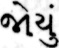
જોયું
